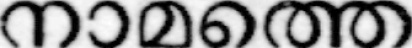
നാമത്തെ
